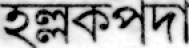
হল্লকপদা
